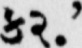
કર.'
